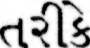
તરીકે
